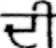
ਦੀ
